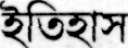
ইতিহাস
